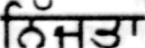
ਨਿੱਜਤਾ
